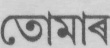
তোমাৰ
